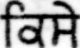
ਕਿਸੇ
